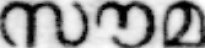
സൌമ
